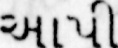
આપી
